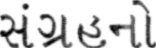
સંગ્રહનો
